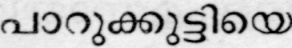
പാറുക്കുട്ടിയെ
